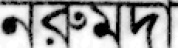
নরুমদা
